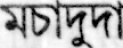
মচাদুদা
